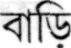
বাড়ি
